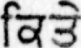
ਕਿਤੇ
